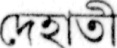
দেহাতী
